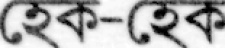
হেক-হেক
